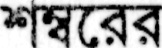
শম্বরের
